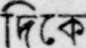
দিকে
